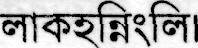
লাকহন্নিংলি।
